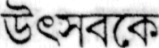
উৎসবকে
